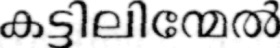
കട്ടിലിന്മേല്‍
